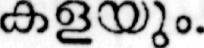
കളയും.
